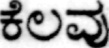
ಕೆಲವು
